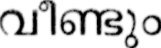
വീണ്ടും
